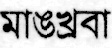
মাঙখ্রবা
